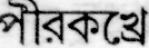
পীরকখ্রে
